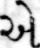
એ
